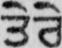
ਤੇਰੇ
